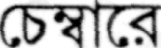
চেম্বারে
